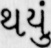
થયું
